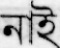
নাই
